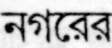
নগরের
